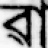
ৱা
